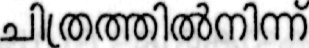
ചിത്രത്തില്‍നിന്ന്
